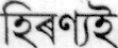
হিৰণ্যই
